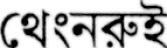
থেংনরুই
